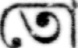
তো
